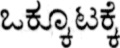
ಒಕ್ಕೂಟಕ್ಕೆ
